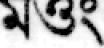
মওং
